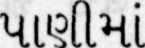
પાણીમાં
